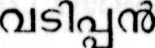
വടിപ്പന്‍
